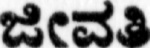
ಜೀವತಿ
